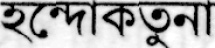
হন্দোকতুনা
